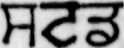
ਸਟਡ
